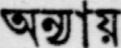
অন্যায়
